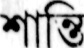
শান্তি
